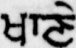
ਖਾਣੇ
